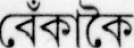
বেঁকাকৈ
